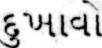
દુખાવો
